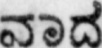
ವಾದ
